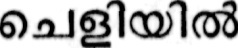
ചെളിയില്‍
